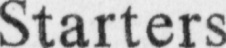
Starters
